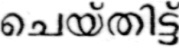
ചെയ്തിട്ട്
